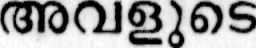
അവളുടെ
